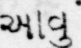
આવું
